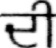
ਦੀ
